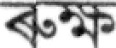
ৰুক্ষ
